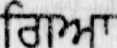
ਗਿਆ
